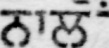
ਨਾਲੋਂ
